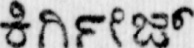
ಕಿರ್ಗೀಜ್
